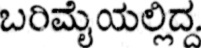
ಬರಿಮೈಯಲ್ಲಿದ್ದ.
